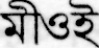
মীওই
